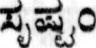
ಸೃಷ್ಟಂ
